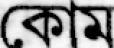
কোম
